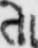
તો
